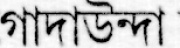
গোদাউন্দা
